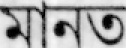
মানত
